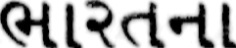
ભારતના
